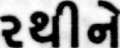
રથીને
